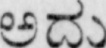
ಅದು
